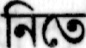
নিতে
